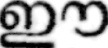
ഈ
